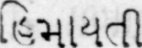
હિમાયતી
